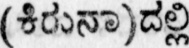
(ಕಿರುನಾ)ದಲ್ಲಿ
